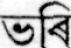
ভৰি
